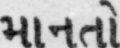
માનતો
